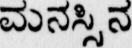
ಮನಸ್ಸಿನ
